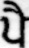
ਪੈ
